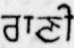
ਰਾਣੀ
